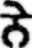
ਨੇ
